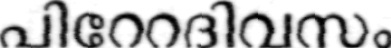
പിറ്റേദിവസം
